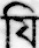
যি
